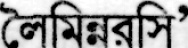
লৈমিন্নরসি’
